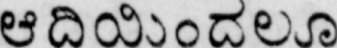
ಆದಿಯಿಂದಲೂ
